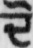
ਦੋ
